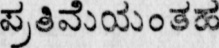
ಪ್ರತಿಮೆಯಂತಹ
